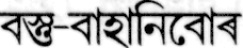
বস্তু-বাহানিবোৰ
